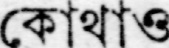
কোথাও
